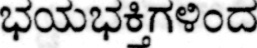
ಭಯಭಕ್ತಿಗಳಿಂದ
